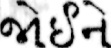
જોઈને
